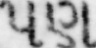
પણ
